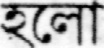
হলো
